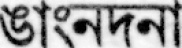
ঙাংনদনা
